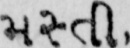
મસ્તી,
